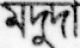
মদুদা
